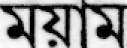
ময়াম
